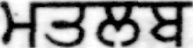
ਮਤਲਬ
